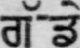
ਗੱਡੇ
